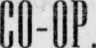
CO-OP.
